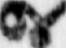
જ
